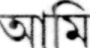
আমি
